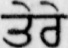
ਤੇਰੇ
